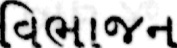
વિભાજન
